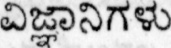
ವಿಜ್ಞಾನಿಗಳು
